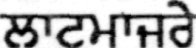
ਲਾਟਮਾਜਰੇ
